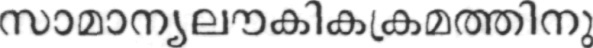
സാമാന്യലൗകികക്രമത്തിനു
